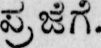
ಪ್ರಜೆಗೆ.
